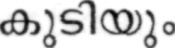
കുടിയും
